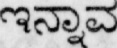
ಇನ್ನಾವ
